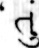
તું
